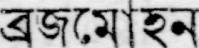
ব্রজমোহন
